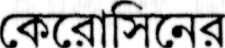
কেরোসিনের
